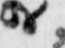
જ,
